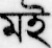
মই
